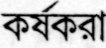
কর্ষকরা
